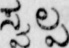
ಸ್ವಲ್ಪ
